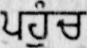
ਪਹੁੰਚ
